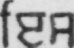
ਇਸ
